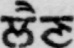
ਲੈਣ
